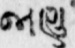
જાણું
